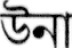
উনা
